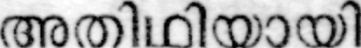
അതിഥിയായി
